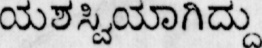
ಯಶಸ್ವಿಯಾಗಿದ್ದು
